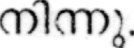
നിന്നു.
